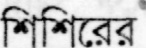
শিশিরের
